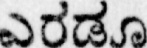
ಎರಡೂ
